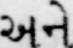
અને
